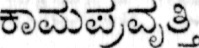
ಕಾಮಪ್ರವೃತ್ತಿ
